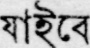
যাইবে
